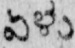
ಏಳು
